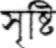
সৃষ্টি
